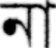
না
